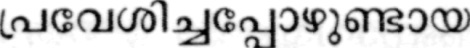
പ്രവേശിച്ചപ്പോഴുണ്ടായ
